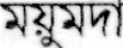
ময়ুমদা
